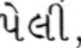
પેલી,
